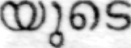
യുടെ
